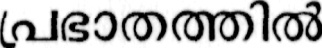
പ്രഭാതത്തില്‍
